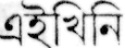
এইখিনি
